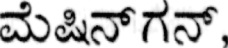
ಮೆಷಿನ್ಗನ್,
